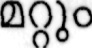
മറ്റും
